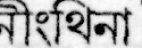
নীংথিনা
